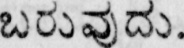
ಬರುವುದು.
